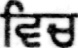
ਵਿਚ
